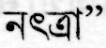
নৎত্রা”
